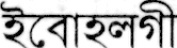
ইবোহলগী
